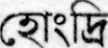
হোংদ্রি
